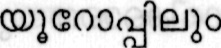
യൂറോപ്പിലും
